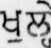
ਖੁਲ੍ਹੇ
